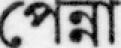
পেন্না
